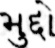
મુદ્દો
